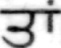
ਤਾਂ
